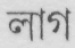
লাগ
